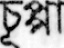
চূপ্পা
